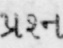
પ્રશ્ન
